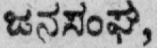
ಜನಸಂಘ,
